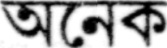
অনেক
